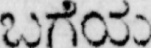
ಬಗೆಯ
